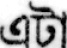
এটা
